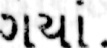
ગયાં.
